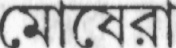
মোষেরা
